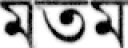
মতম
